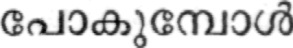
പോകുമ്പോള്‍
